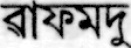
ৱাফমদু
